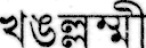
খঙল্লম্মী
